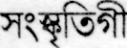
সংস্কৃতিগী
